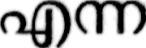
എന്ന
